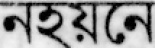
নহয়নে
